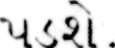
પડશે.
